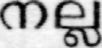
നല്ല
